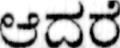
ಆದರೆ
